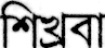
শিখ্রবা
